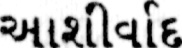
આશીર્વાદ
